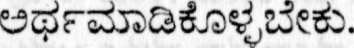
ಅರ್ಥಮಾಡಿಕೊಳ್ಳಬೇಕು.
